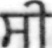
ਸੀ
